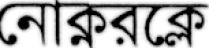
নোক্নরক্লে
